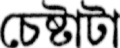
চেষ্টাটা
